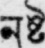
নষ্ট
